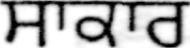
ਸਾਕਾਰ
